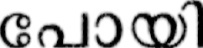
പോയി
